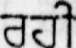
ਰਹੀ
